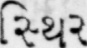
સ્થિર
